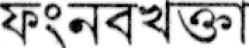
ফংনবখক্তা
